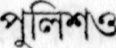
পুলিশও
